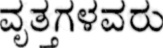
ವೃತ್ತಗಳವರು
